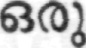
ഒരു
